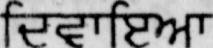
ਦਿਵਾਇਆ
